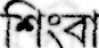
শিংবা
